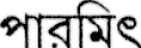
পারমিৎ
